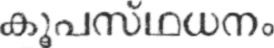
കൂപസ്ഥധനം
